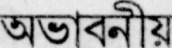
অভাবনীয়
